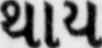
થાય
